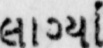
લાગ્યાં
